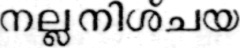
നല്ലനിശ്ചയ
